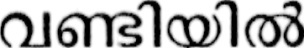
വണ്ടിയില്‍
